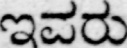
ಇವರು
